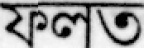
ফলত
